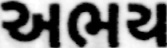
અભય
